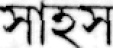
সাহস
